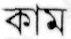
কাম
